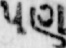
પણ
